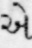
એ
